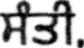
ਸੰਤੀ,
